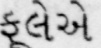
ફૂલેએ
